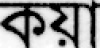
কয়া
